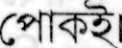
পোকই।
